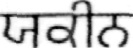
ਯਕੀਨ
